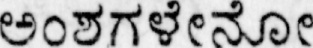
ಅಂಶಗಳೇನೋ
